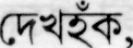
দেখহঁক,
